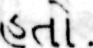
હતો.
